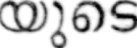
യുടെ
